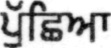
ਪੁੱਛਿਆ
